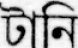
টানি
